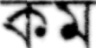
কম
